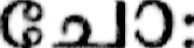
ചോ:
